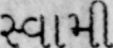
સ્વામી
